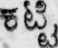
ಕಟ್ಟೆ
